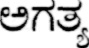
ಅಗತ್ಯ
